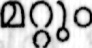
മറ്റും
